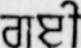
ਗਈ
